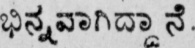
ಭಿನ್ನವಾಗಿದ್ದಾನೆ.
